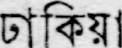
ঢাকিয়া
